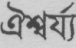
ঐশ্বৰ্য্য
